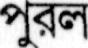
পুরল
